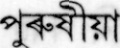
পুৰুষীয়া
